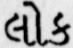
લોક
